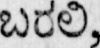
ಬರಲಿ,
